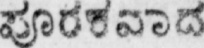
ಪೂರಕವಾದ
